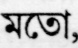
মতো,
